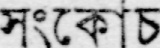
সংকোচ
